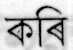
কৰি
